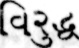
વિરુદ્ધ
